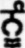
ਨੂੰ
